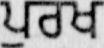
ਪੁਰਖ
